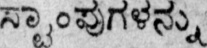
ಸ್ಟಾಂಪುಗಳನ್ನು
